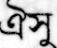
ঐসু
